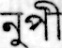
নুপী
